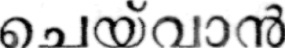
ചെയ്വാന്‍
